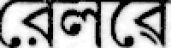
রেলৱে
